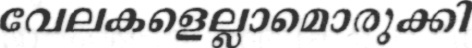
വേലകളെല്ലാമൊരുക്കി
